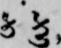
કંકુ,
